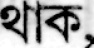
থাক,
